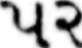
પર
